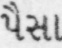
પૈસા
